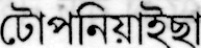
টোপনিয়াইছা
